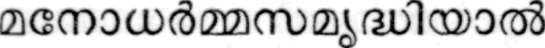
മനോധര്‍മ്മസമൃദ്ധിയാല്‍
